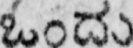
ಒಂದು
